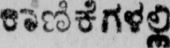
ಕಾಣಿಕೆಗಳಲ್ಲಿ
